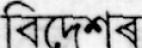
বিদেশৰ
